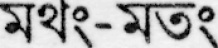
মথং-মতং
